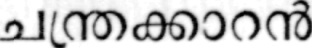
ചന്ത്രക്കാറന്‍
